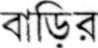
বাড়ির
